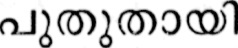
പുതുതായി
